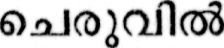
ചെരുവില്‍
